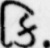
કિ.
